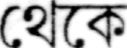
থেকে
